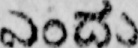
ಎಂದು
